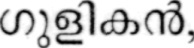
ഗുളികന്‍,
